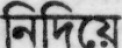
নিদিয়ে
